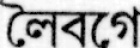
লৈবগে
